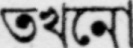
তখনো
